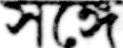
সঙ্গে
